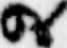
જ
